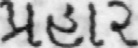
પ્રહાર
